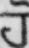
ਹੋ
